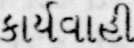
કાર્યવાહી
